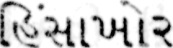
હિંસાખોર
